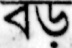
বড়
